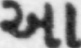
આ
